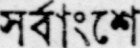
সর্বাংশে
